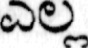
ಎಲ್ಲ
